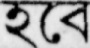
হবে
